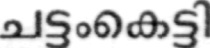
ചട്ടംകെട്ടി
